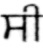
ਸੀ
